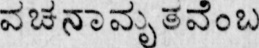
ವಚನಾಮೃತವೆಂಬ
